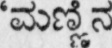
‘ಮಣ್ಣಿನ
